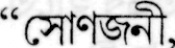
"সোণজনী,
